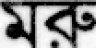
মরু
